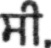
ਸੀ,
